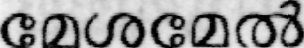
മേശമേല്‍
